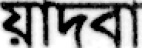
য়াদবা
